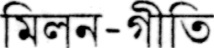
মিলন-গীতি
